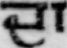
ਦਾ
